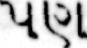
પણ
